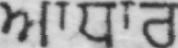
ਆਧਾਰ
